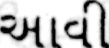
આવી
